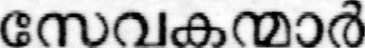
സേവകന്മാര്‍
